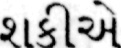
શકીએ
